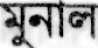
মুনাল
